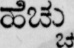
ಹೆಚ್ಚು
